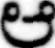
ಆ
